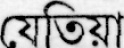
যেতিয়া
